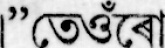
"তেওঁৰো
